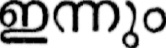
ഇന്നും
